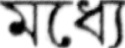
মধ্যে
